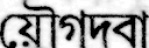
য়ৌগদবা
